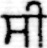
ਸੀ
